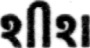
શીશ
